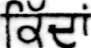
ਕਿੱਦਾਂ
